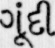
ગૂંદી
